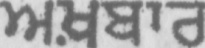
ਅਖ਼ਬਾਰ
